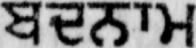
ਬਦਨਾਮ
